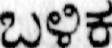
ಬಳಿಕ
